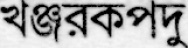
খঞ্জরকপদু
